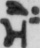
ਮੈਂ
